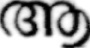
ആ
